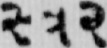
સ્વર
